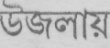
উজলায়
